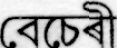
বেচেৰী
